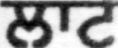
ਲਾਟ
